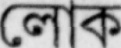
লোক
